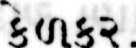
કેળકર.
